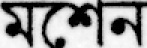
মশেন
